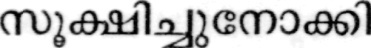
സൂക്ഷിച്ചുനോക്കി
